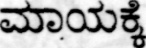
ಮಾಯಕ್ಕೆ
